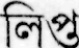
লিপ্ত
